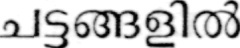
ചട്ടങ്ങളില്‍
